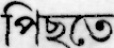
পিছতে
